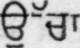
ਉੱਚਾ
